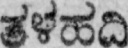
ತಳಹದಿ
